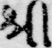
શ્રી
